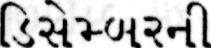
ડિસેમ્બરની
